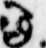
છે.
